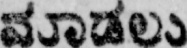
ಮಾಡಲು
